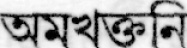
অমখক্তনি
